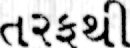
તરફથી
